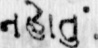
નહોતું.
